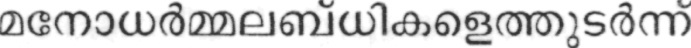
മനോധര്‍മ്മലബ്ധികളെത്തുടര്‍ന്ന്
